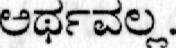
ಅರ್ಥವಲ್ಲ.
